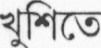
খুশিতে
